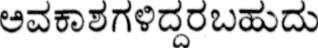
ಅವಕಾಶಗಳಿದ್ದರಬಹುದು
